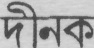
দীনক
